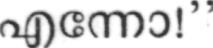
എന്നോ!"
